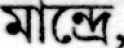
মান্দ্রে,
